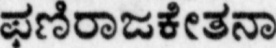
ಫಣಿರಾಜಕೇತನಾ
